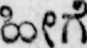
ಹೀಗೆ
